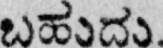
ಬಹುದು.
